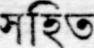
সহিত
